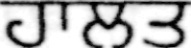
ਹਾਲਤ
